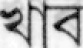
খাব
